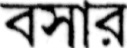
বসার
